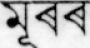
মূৰৰ
